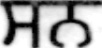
ਸਨ
